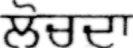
ਲੋਚਦਾ
